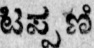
ಟಿಪ್ಪಣಿ
